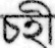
চহী
